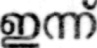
ഇന്ന്
